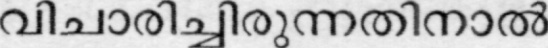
വിചാരിച്ചിരുന്നതിനാല്‍
